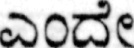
ಎಂದೇ
